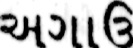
અગાઉ
